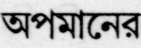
অপমানের
